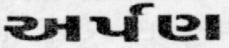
અર્પણ
